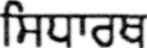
ਸਿਧਾਰਥ
